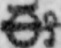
ಈ
